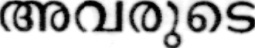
അവരുടെ
